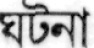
ঘটনা
